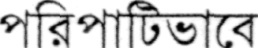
পরিপাটিভাবে
